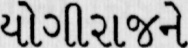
યોગીરાજને
